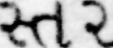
સ્તર
